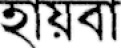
হায়বা
